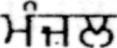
ਮੰਜ਼ਲ
